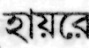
হায়রে
